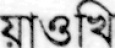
য়াওখি
